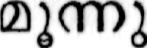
മൂന്നു
